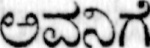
ಅವನಿಗೆ
